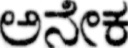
ಅನೇಕ
